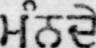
ਮੰਨਦੇ
